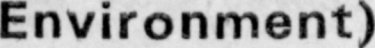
Environment)
